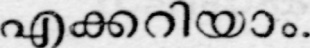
എക്കറിയാം.
